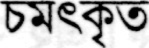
চমৎকৃত
